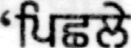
'ਪਿਛਲੇ
